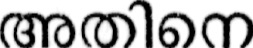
അതിനെ
